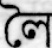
লৈ
